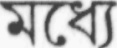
মধ্যে
